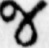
જ
